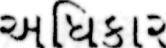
અધિકાર
